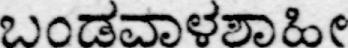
ಬಂಡವಾಳಶಾಹೀ
